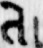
તો
